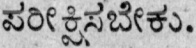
ಪರೀಕ್ಷಿಸಬೇಕು.
